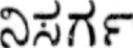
ನಿಸರ್ಗ
